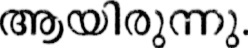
ആയിരുന്നു.
